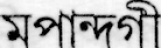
মপান্দগী
